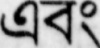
এবং
